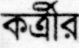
কর্ত্রীর
